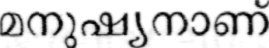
മനുഷ്യനാണ്
